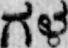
ಗಳ
